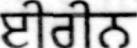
ਈਰੀਨ
